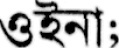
ওইনা;
